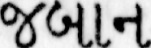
જબાન
